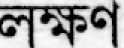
লক্ষণ
